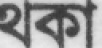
থকা
